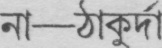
না-ঠাকুর্দা
